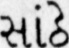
સાંઠે
